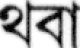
থবা
